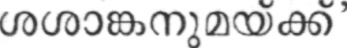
ശശാങ്കനുമയ്ക്ക"
